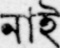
নাই
